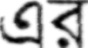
এর
